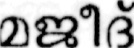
മജീദ്
